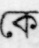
কে
